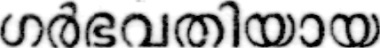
ഗര്‍ഭവതിയായ
